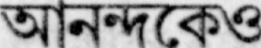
আনন্দকেও
